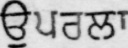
ਉਪਰਲਾ
